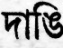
দাঙি
